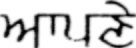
ਆਪਣੇ
